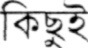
কিছুই
